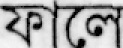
ফালে
